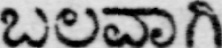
ಬಲವಾಗಿ
